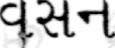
વસન
